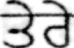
ਤੇਰੇ
